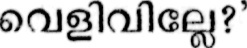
വെളിവില്ലേ?’
